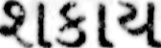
શકાય
